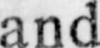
and
